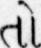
તો
